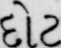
દોટ
